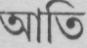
আতি
